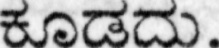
ಕೂಡದು.
